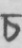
চ
